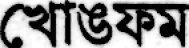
খোঙফম
